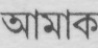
আমাক
